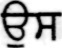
ਉਸ
